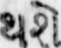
થશે
